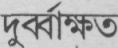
দুৰ্ব্বাক্ষত
